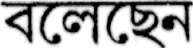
বলেছেন
